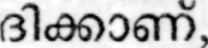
ദിക്കാണ്,
